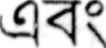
এবং
